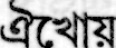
ঐখোয়
